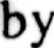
by
